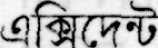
এক্সিদেন্ট
